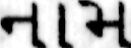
નામ
